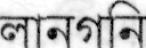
লানগনি
